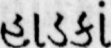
હાડકાં
